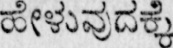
ಹೇಳುವುದಕ್ಕೆ
